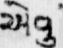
એવું
